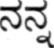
ನನ್ನ
